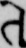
તે
